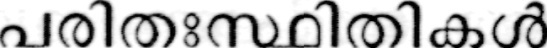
പരിതഃസ്ഥിതികള്‍
